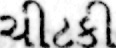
ચીટકી
